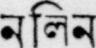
নলিন
